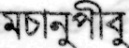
মচানুপীবু
